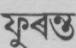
ফুৰন্ত
